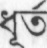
ধূর্ত
